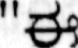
“ಈ
